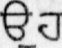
ਉਹ
